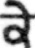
ਕੇ
